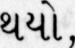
થયો,
